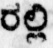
ರಲ್ಲಿ
